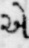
એ
